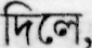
দিলে,
